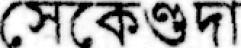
সেকেণ্ডদা
